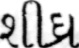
શીઘ્ર
